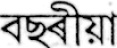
বছৰীয়া
